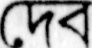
দেব
